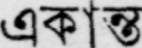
একান্ত
